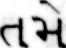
તમે
